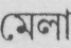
মেলা
